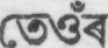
তেওঁৰ
